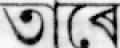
তাৰে
